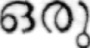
ഒരു
